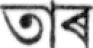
তাৰ
